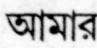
আমার
